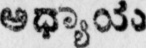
ಅಧ್ಯಾಯ
